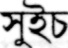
সুইচ
